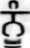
ਨੂੰ
